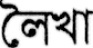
লৈখা
